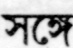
সঙ্গে
